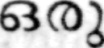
ഒരു
